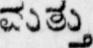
ಮತ್ತು
